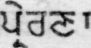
ਪ੍ਰੇਰਣਾ
